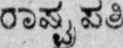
ರಾಷ್ಟ್ರಪತಿ
